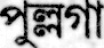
পুল্লগা
